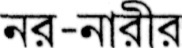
নর-নারীর
